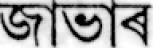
জাভাৰ
